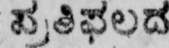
ಪ್ರತಿಫಲದ
